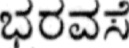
ಭರವಸೆ
